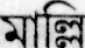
মাল্লি
